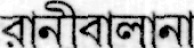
রানীবালানা
